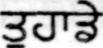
ਤੁਹਾਡੇ
